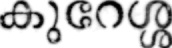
കുറേശ്ശ
